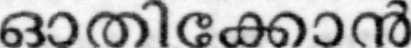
ഓതിക്കോന്‍
